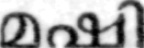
മഷി
